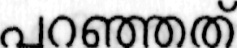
പറഞ്ഞത്
